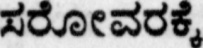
ಸರೋವರಕ್ಕೆ
